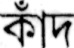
কাঁদ
